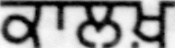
ਕਾਲਖ਼
